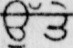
ਉੱਤੇ
